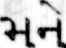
મને
